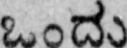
ಒಂದು
